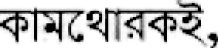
কামথোরকই,
